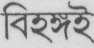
বিহঙ্গই
